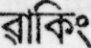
ৱাকিং
